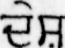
ਦੇਸ਼
